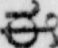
ಈ
